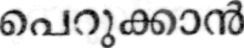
പെറുക്കാന്‍
